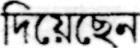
দিয়েছেন
